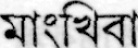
মাংখিবা
